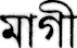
মাগী
